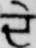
ਦੇ
